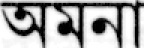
অমনা
